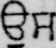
ਉਸ
